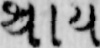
થાય
